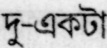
দু-একটা
